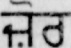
ਜ਼ੋਰ
